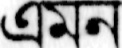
এমন
